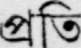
প্রতি
